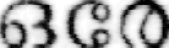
ഒരേ
